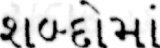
શબ્દોમાં
